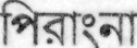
পিরাংনা
